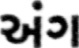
અંગ
